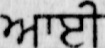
ਆਈ
